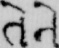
તેને
